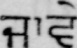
ਜਾਵੇ
